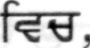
ਵਿਚ,
